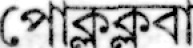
পোক্লক্লবা
